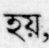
হয়,
